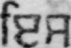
ਇਸ
